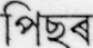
পিছৰ
